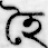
হৈ
